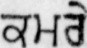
ਕਮਰੇ
